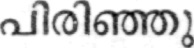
പിരിഞ്ഞു
